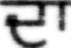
ਦਾ
